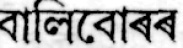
বালিবোৰৰ
